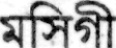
মসিগী
